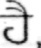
ਹੈ,
